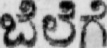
ಬೆಲೆಗೆ
